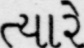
ત્યારે
